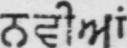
ਨਵੀਆਂ
